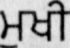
ਮੁਖੀ
